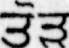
ਤੋੜ
